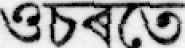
ওচৰতে
